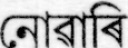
নোৱাৰি
